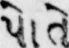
પોતે
